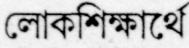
লোকশিক্ষার্থে
